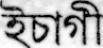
ইচাগী
